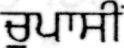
ਚੁਪਾਸੀ
